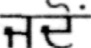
ਜਦੋਂ
